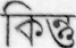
কিন্তু
